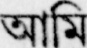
আমি
